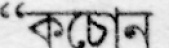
"কচোন
